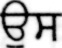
ਉਸ
